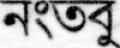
নংতবু
